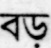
বড়
